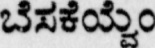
ಬೆಸಕೆಯ್ವೆಂ
